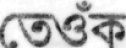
তেওঁক
